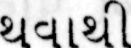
થવાથી
